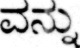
ವನ್ನು
